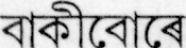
বাকীবোৰে
